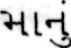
માનું
